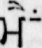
ਮੈਂ
